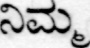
ನಿಮ್ಮ
